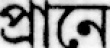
প্রানে
